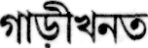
গাড়ীখনত
